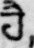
ਹੈ,
